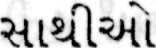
સાથીઓ
